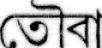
তৌবা
